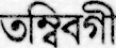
তম্বিবগী
